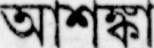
আশঙ্কা
